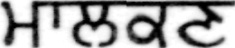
ਮਾਲਕਣ
